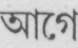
আগে
